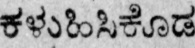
ಕಳುಹಿಸಿಕೊಡ
